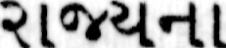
રાજ્યના
